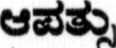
ಆಪತ್ಸು
